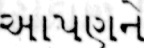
આપણને
